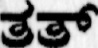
ತತ್
